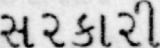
સરકારી
